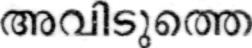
അവിടുത്തെ
